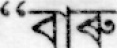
"বাৰু
